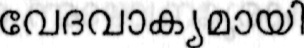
വേദവാക്യമായി
